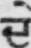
ਦੇ
